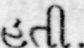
હતી.
